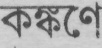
কঙ্কণে
